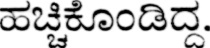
ಹಚ್ಚಿಕೊಂಡಿದ್ದ.
